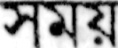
সময়
